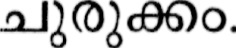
ചുരുക്കം.
